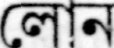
লোন
